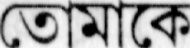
তোমাকে
